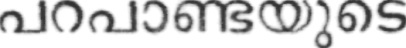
പറപാണ്ടയുടെ
